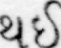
થઈ
